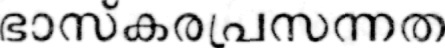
ഭാസ്കരപ്രസന്നത
